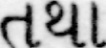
તથા
